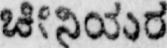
ಚೀನಿಯರ
